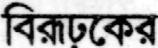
বিরূঢ়কের
